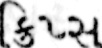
ક્રિપ્સ
